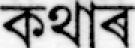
কথাৰ
